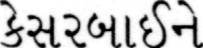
કેસરબાઈને
